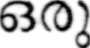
ഒരു
